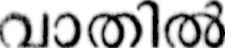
വാതില്‍
